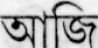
আজি
